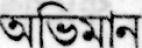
অভিমান
